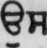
ਉਸ
